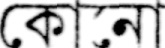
কোনো
